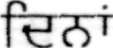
ਦਿਨਾਂ
